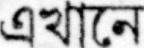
এখানে
